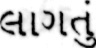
લાગતું
